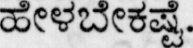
ಹೇಳಬೇಕಷ್ಟೆ.
